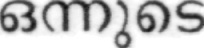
ഒന്നുടെ
